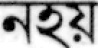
নহয়
